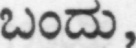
ಬಂದು,
